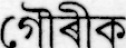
গৌৰীক
